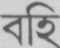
বহি
